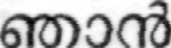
ഞാന്‍
